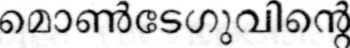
മൊണ്‍ടേഗുവിന്റെ
